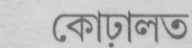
কোঢ়ালত
